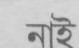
নাই
